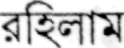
রহিলাম
